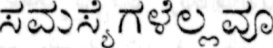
ಸಮಸ್ಯೆಗಳೆಲ್ಲವೂ
